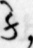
કે,
